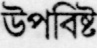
উপবিষ্ট
